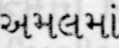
અમલમાં
